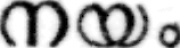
നയം
